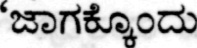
‘ಜಾಗಕ್ಕೊಂದು
